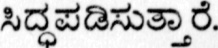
ಸಿದ್ಧಪಡಿಸುತ್ತಾರೆ.
